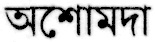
অশোমদা
